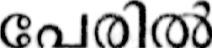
പേരില്‍
